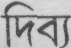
দিব্য
